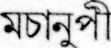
মচানুপী
